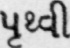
પૃથ્વી
